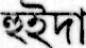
হুইদা
